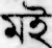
মই
